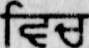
ਵਿਚ
